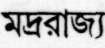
মদ্ররাজ্য
